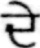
ਦੇ
